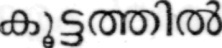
കൂട്ടത്തില്‍
